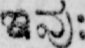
ಇವು:
